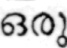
ഒരു
